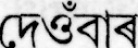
দেওঁবাৰ
